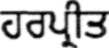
ਹਰਪ੍ਰੀਤ
